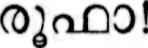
രൂഫാ!
